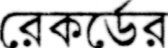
রেকর্ডের
